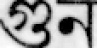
গুন
